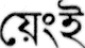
য়েংই
